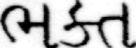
ભક્ત
